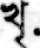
খৃ.
